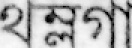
থম্লগা
